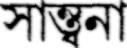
সান্ত্বনা
